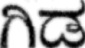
ಗಿಡ
